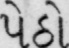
પેઠો
